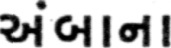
અંબાના
